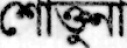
শোক্তুনা
